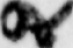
જ
